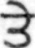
ਤੇ
